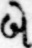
બે
